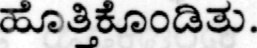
ಹೊತ್ತಿಕೊಂಡಿತು.
